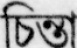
চিন্তা
